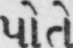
પોતે
